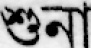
শুনা
